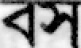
বস
